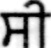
ਸੀ
